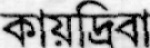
কায়দ্রিবা
